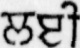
ਲਈ
